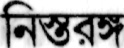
নিস্তরঙ্গ
